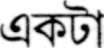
একটা
